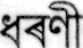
ধৰণী
